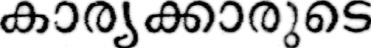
കാര്യക്കാരുടെ
